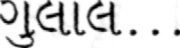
ગુલાલ...
